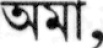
অমা,
